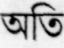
অতি
